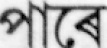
পাৰে
